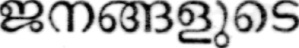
ജനങ്ങളുടെ
